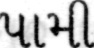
પામી
